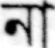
না
